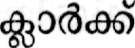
ക്ലാര്‍ക്ക്
